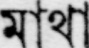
মাথা
